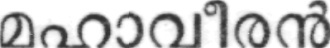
മഹാവീരന്‍
